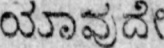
ಯಾವುದೇ
